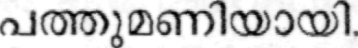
പത്തുമണിയായി.
